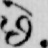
છે.
